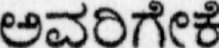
ಅವರಿಗೇಕೆ
